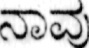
ನಾವು
